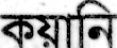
কয়ানি
